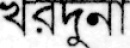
খরদুনা
